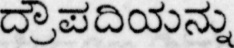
ದ್ರೌಪದಿಯನ್ನು
